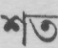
শত
